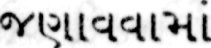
જણાવવામાં
